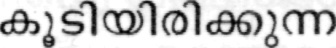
കൂടിയിരിക്കുന്ന
